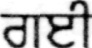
ਗਈ
